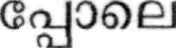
പ്പോലെ
